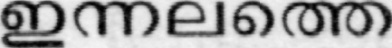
ഇന്നലത്തെ
